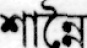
শান্নৈ
